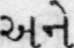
અને
